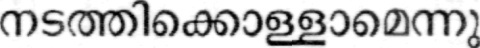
നടത്തിക്കൊള്ളാമെന്നു
